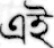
এই
